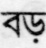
বড়
